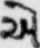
એ
